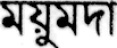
ময়ুমদা
